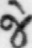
જે
